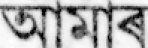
আমাৰ
